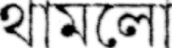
থামলো
